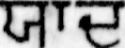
ਯਾਦ
